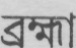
ব্ৰহ্মা
